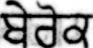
ਬੇਰੋਕ
